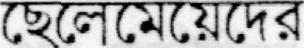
ছেলেমেয়েদের
